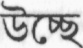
উচ্ছে
